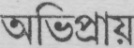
অভিপ্ৰায়
